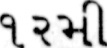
૧૨મી
